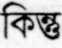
কিন্তু
